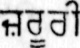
ਜ਼ਰੂਰੀ
